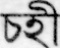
চহী
